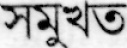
সমুখত
